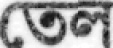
তেল
